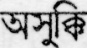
অসুক্কি
